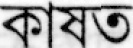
কাষত
